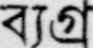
ব্যগ্র
